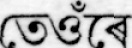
তেওঁৰে
